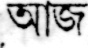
আজ
